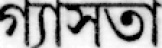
গ্যাসতা
